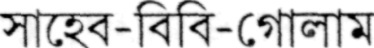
সাহেব-বিবি-গোলাম
